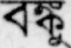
বঙ্কু
